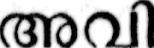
അവി
